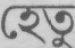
হেতু
